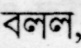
বলল,
